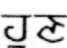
ਹੁਣ
